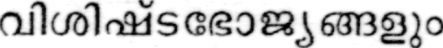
വിശിഷ്ടഭോജ്യങ്ങളും
